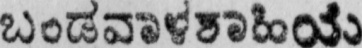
ಬಂಡವಾಳಶಾಹಿಯ
